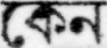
কেন
